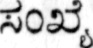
ಸಂಖ್ಯೆ
